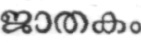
ജാതകം
